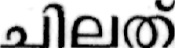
ചിലത്
